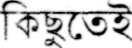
কিছুতেই
